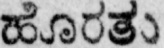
ಹೊರತು
